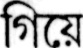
গিয়ে
